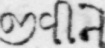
જીવીને
